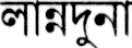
লান্নদুনা
